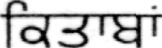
ਕਿਤਾਬਾਂ
